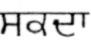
ਸਕਦਾ
